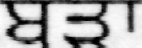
ਬੜਾ
